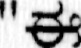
“ಈ
